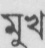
মুখ
